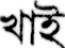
খাই
